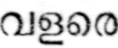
വളരെ
